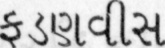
ફડણવીસ
